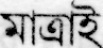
মাত্রাই
